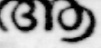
ആ
